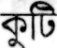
কুটি
